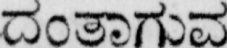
ದಂತಾಗುವ
